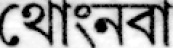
থোংনবা
